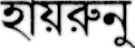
হায়রুনু
